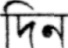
দিন
